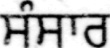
ਸੰਸਾਰ
